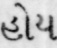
હોય
